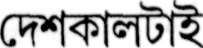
দেশকালটাই
